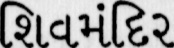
શિવમંદિર
